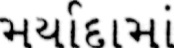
મર્યાદામાં
